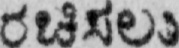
ರಚಿಸಲು
